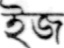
ইজ
